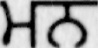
ਮਨ
